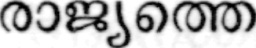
രാജ്യത്തെ
